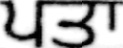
ਪਤਾ
